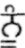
ਨੂੰ
